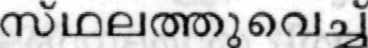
സ്ഥലത്തുവെച്ച്
